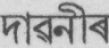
দাৱনীৰ
